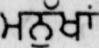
ਮਨੁੱਖਾਂ
